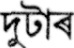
দুটাৰ
